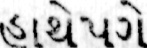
હાથેપગે
